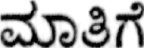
ಮಾತಿಗೆ
